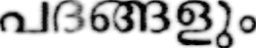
പദങ്ങളും
